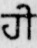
ਹੀ
